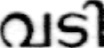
വടി
